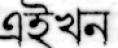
এইখন
